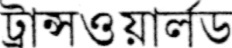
ট্রান্সওয়ার্লড
